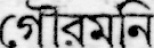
গৌরমনি
